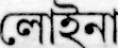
লোইনা
